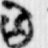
છે
